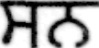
ਸਨ
